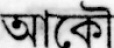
আকৌ
